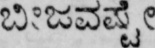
ಬೀಜವಷ್ಟೇ
